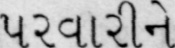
પરવારીને
